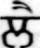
ਲੈ
